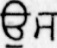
ਉਸ
